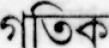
গতিক
